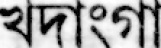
খদাংগা
